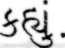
કહ્યું.
